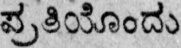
ಪ್ರತಿಯೊಂದು
